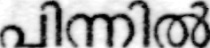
പിന്നില്‍
